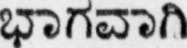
ಭಾಗವಾಗಿ
